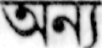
অন্য
